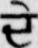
ਦੇ
